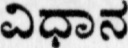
ವಿಧಾನ
